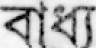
বাধ্য
